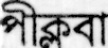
পীক্লবা
